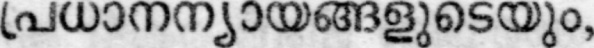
പ്രധാനന്യായങ്ങളുടെയും,
